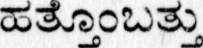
ಹತ್ತೊಂಬತ್ತು
